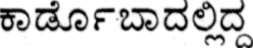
ಕಾರ್ಡೊಬಾದಲ್ಲಿದ್ದ
